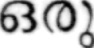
ഒരു
